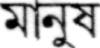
মানুষ
